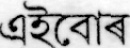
এইবোৰ
